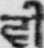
ਵੀ
